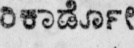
ರಿಕಾರ್ಡೋ
